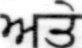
ਅਤੇ
